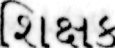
શિક્ષક
